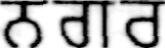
ਨਗਰ
